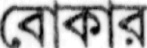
বোকার
